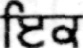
ਇਕ
